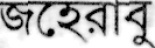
জহেরাবু
